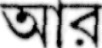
আর
